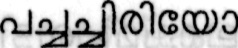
പച്ചച്ചിരിയോ
